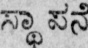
ಸ್ಥಾಪನೆ
